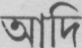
আদি
